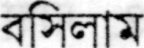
বসিলাম
